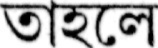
তাহলে
